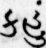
કહું
